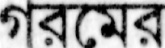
গরমের
